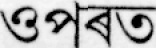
ওপৰত
